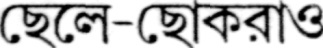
ছেলে-ছোকরাও
